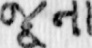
જૂના
